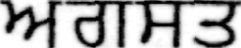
ਅਗਸਤ
